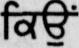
ਕਿਉਂ
